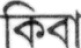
কিবা
